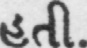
હતી.
